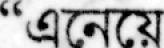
"এনেয়ে
